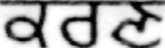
ਕਰਣ
